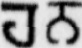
ਹਨ
